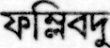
ফম্লিবদু
